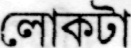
লোকটা
